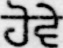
ਹੋਵੇ
